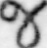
જ
